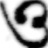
ও
